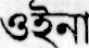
ওইনা
